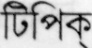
টিপিক্
